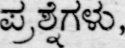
ಪ್ರಶ್ನೆಗಳು,
